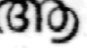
ആ
